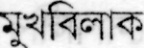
মুখবিলাক
